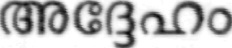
അദ്ദേഹം
